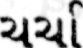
ચર્ચા
